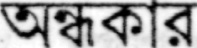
অন্ধকার
